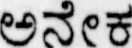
ಅನೇಕ
